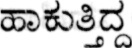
ಹಾಕುತ್ತಿದ್ದ
